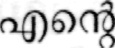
എന്റെ
